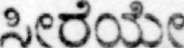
ಸೀರೆಯೇ
